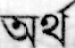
অর্থ
